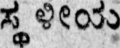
ಸ್ಥಳೀಯ
